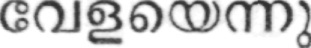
വേളയെന്നു
